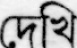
দেখি
